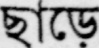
ছাড়ে
